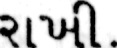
રાખી.
